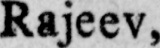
Rajeev,
